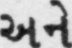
અને
